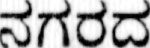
ನಗರದ
